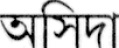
অসিদা
